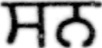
ਸਨ
